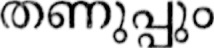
തണുപ്പും
